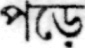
পড়ে
